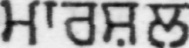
ਮਾਰਸ਼ਲ
